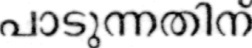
പാടുന്നതിന്
